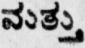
ಮತ್ತು
